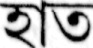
হাত
